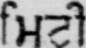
ਮਿਟੀ
